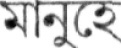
মানুহে
